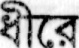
ধীরে
